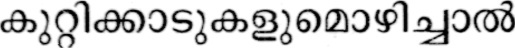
കുറ്റിക്കാടുകളുമൊഴിച്ചാല്‍
